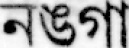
নঙগা
